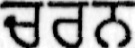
ਚਰਨ
